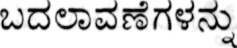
ಬದಲಾವಣೆಗಳನ್ನು
